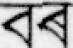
বৰ
